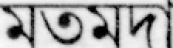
মতমদা
